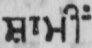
ਸ਼ਾਮੀਂ
